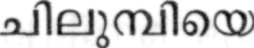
ചിലുമ്പിയെ
